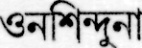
ওনশিন্দুনা
